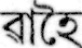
ৱাহৈ
